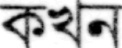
কখন
